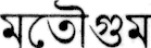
মতৌগুম
